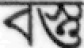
বস্তু
